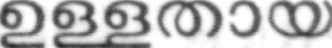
ഉള്ളതായ
